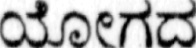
ಯೋಗದ
